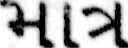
માત્ર
